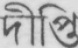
দীপ্তি
